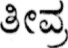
ತೀವ್ರ
